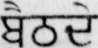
ਬੈਠਦੇ
